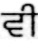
ਵੀ
